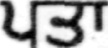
ਪਤਾ
